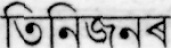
তিনিজনৰ
